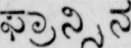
ಫ್ರಾನ್ಸಿನ
